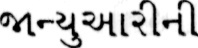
જાન્યુઆરીની
